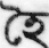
হৈ
